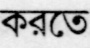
করতে
